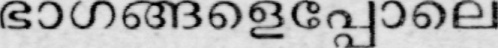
ഭാഗങ്ങളെപ്പോലെ
